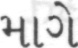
માગે
